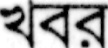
খবর
